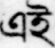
এই
